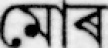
মোৰ
